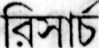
রিসার্চ
